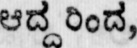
ಆದ್ದರಿಂದ,
